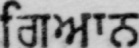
ਗਿਆਨ
